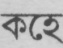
কহে
